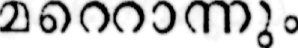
മറെറാന്നും
